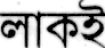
লাকই
